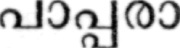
പാപ്പരാ
